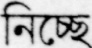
নিচ্ছে
